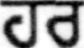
ਹਰ
